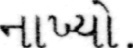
નાખ્યો.
